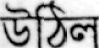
উঠিল
